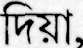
দিয়া,
